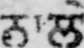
ਨਾਲੇ
